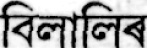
বিলালিৰ
